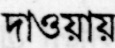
দাওয়ায়
